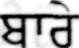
ਬਾਰੇ
